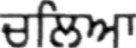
ਚਲਿਆ
